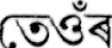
তেওঁৰ
